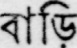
বাড়ি
